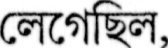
লেগেছিল,
